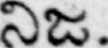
ನಿಜ.
